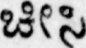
ಚೀನಿ
